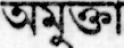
অমুক্তা
